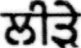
ਲੀੜੇ
